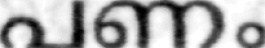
പണം
